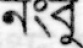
নংবু
